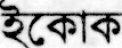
ইকোক
